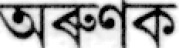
অৰুণক
